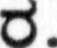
ರ.
